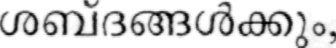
ശബ്ദങ്ങള്‍ക്കും,
